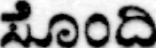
ಸೊಂದಿ
